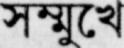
সম্মুখে
